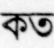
কত
